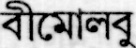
বীমোলবু
